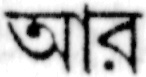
আর
